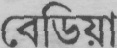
বেড়িয়া
